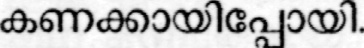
കണക്കായിപ്പോയി.
